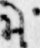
મેં
